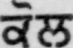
ਕੋਲ
